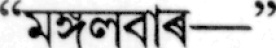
"মঙ্গলবাৰ-"
